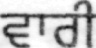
ਵਾਰੀ
